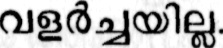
വളര്‍ച്ചയില്ല.
